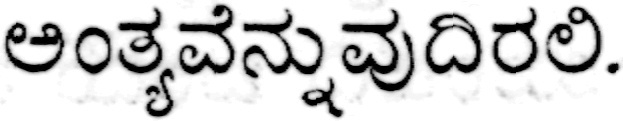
ಅಂತ್ಯವೆನ್ನುವುದಿರಲಿ.
